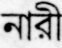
নারী
